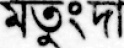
মতুংদা
